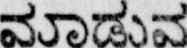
ಮಾಡುವ
